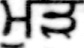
ਮੁੜ
